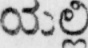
ಯಲ್ಲಿ
